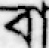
বা
